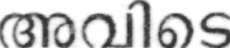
അവിടെ
